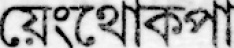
য়েংথোকপা
